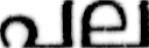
പല
